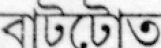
বাটটোত
